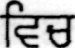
ਵਿਚ
